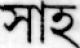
সাহ
